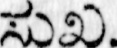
ಸುಖ.
